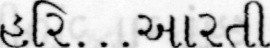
હરિ...આરતી
